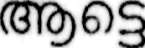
ആട്ടെ
